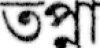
তপ্না
